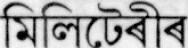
মিলিটেৰীৰ
